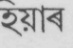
হিয়াৰ
